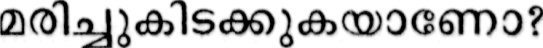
മരിച്ചുകിടക്കുകയാണോ?
